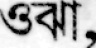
ওঝা,
